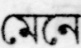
মেনে
